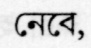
নেবে,
